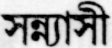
সন্ন্যাসী
